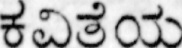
ಕವಿತೆಯ
